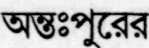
অন্তঃপুরের
